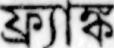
ফ্র্যাঙ্ক
